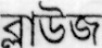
ব্লাউজ
